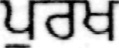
ਪੁਰਖ
